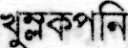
খুম্লকপনি
